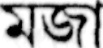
মজা
